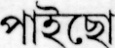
পাইছো
